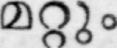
മറ്റും
